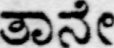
ತಾನೇ
